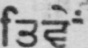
ਤਿਵੇਂ
